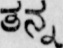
ತನ್ನ
